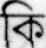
কি
